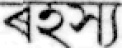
ৰহস্য
